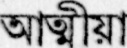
আত্মীয়া
